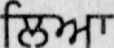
ਲਿਆ
